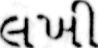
લખી
